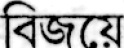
বিজয়ে
